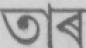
তাৰ
